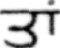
ਤਾਂ
